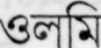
ওলমি
